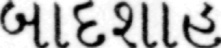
બાદશાહ
